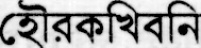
হৌরকখিবনি
